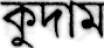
কুদাম
